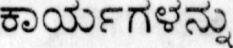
ಕಾರ್ಯಗಳನ್ನು
